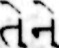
તેને
